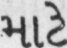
માટે
